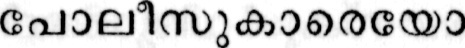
പോലീസുകാരെയോ
